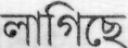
লাগিছে
